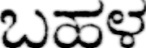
ಬಹಳ
